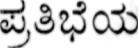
ಪ್ರತಿಭೆಯ
